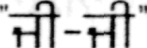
''ਜੀ-ਜੀ''
